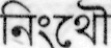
নিংথৌ
